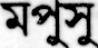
মপুসু
